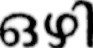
ഒഴി
